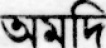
অমদি
